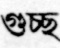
গুচ্ছ
